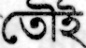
তৌই
